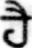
ਹੈ
